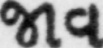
જાવ
